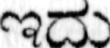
ಇದು
